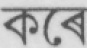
কৰে
